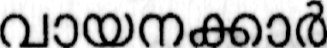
വായനക്കാര്‍
